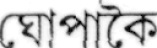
ঘোপাকৈ
